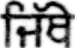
ਜਿੱਥੇ
